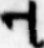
ન
